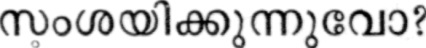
സംശയിക്കുന്നുവോ?
